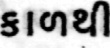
કાળથી
